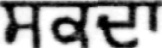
ਸਕਦਾ
